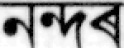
নন্দৰ
